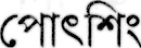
পোৎশিং
